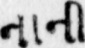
નાની
